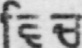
ਵਿਚ
